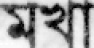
মখা
